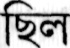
ছিল
